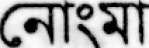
নোংমা
